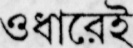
ওধারেই
